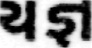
યજ્ઞ
